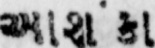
આશંકા
